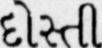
દોસ્તી
